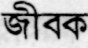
জীবক
